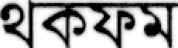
থকফম
